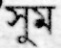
’সুম
